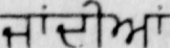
ਜਾਂਦੀਆਂ
